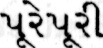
પૂરેપૂરી
